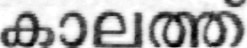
കാലത്ത്
